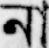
না
